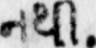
નથી.
